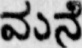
ಮನೆ
